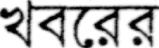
খবরের
